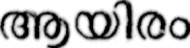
ആയിരം
